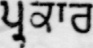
ਪ੍ਰਕਾਰ
